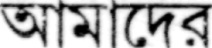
আমাদের
